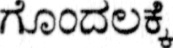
ಗೊಂದಲಕ್ಕೆ
